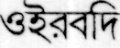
ওইরবদি
